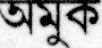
অমুক
